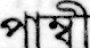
পাম্বী
